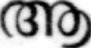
ആ
